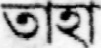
তাহা
